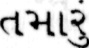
તમારું
